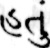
હતું
